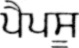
ਪੈਪਸੂ
